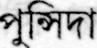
পুন্সিদা
